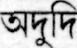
অদুদি
